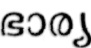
ഭാര്യ
